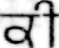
ਕੀ
